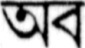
অব
